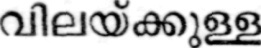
വിലയ്ക്കുള്ള
